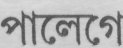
পালেগে
